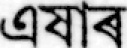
এষাৰ
